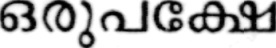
ഒരുപക്ഷേ
